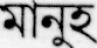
মানুহ
